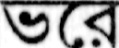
ভরে
